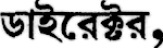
ডাইরেক্টর,
